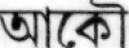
আকৌ
